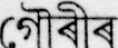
গৌৰীৰ
